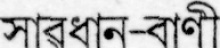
সাৱধান-বাণী
